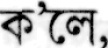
ক'লে,
